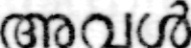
അവള്‍
